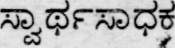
ಸ್ವಾರ್ಥಸಾಧಕ
